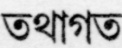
তথাগত
